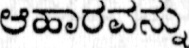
ಆಹಾರವನ್ನು
